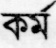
কর্ম
